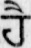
ਹੈ
